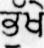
ਭੁੱਖੇ
